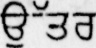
ਉੱਤਰ
